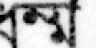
ধম্ম
